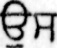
ਉਸ
